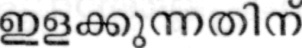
ഇളക്കുന്നതിന്
